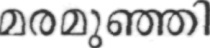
മരമുഞ്ഞി
